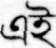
এই
